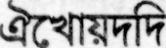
ঐখোয়দদি
